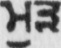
ਮੁੜ
